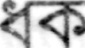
ধক
